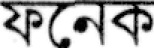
ফনেক
